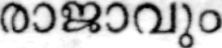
രാജാവും
